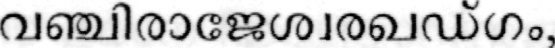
വഞ്ചിരാജേശ്വരഖഡ്ഗം,
